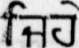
ਜਿਹੇ
